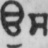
ਉਸ
